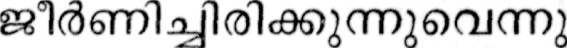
ജീര്‍ണിച്ചിരിക്കുന്നുവെന്നു
